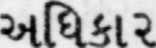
અધિકાર
